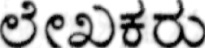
ಲೇಖಕರು
